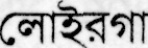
লোইরগা
